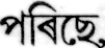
পৰিছে,
